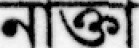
নাক্তা
